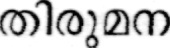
തിരുമന
